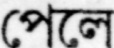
পেলে
